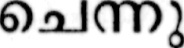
ചെന്നു
